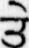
ਤੇ
